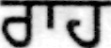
ਰਾਹ
